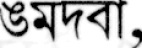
ঙমদবা,
